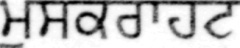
ਮੁਸਕਰਾਹਟ
